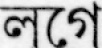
লগে
